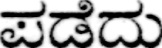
ಪಡೆದು
